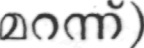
മറന്ന്)
